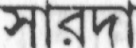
সারদা
